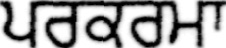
ਪਰਕਰਮਾ
